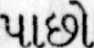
પાછો
